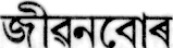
জীৱনবোৰ
